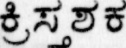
ಕ್ರಿಸ್ತಶಕ
